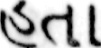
હતા
